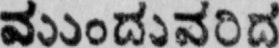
ಮುಂದುವರಿದ
